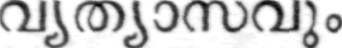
വ്യത്യാസവും
